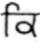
ਕਿ
